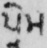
ਪ੍ਰੇਮ
